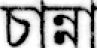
চান্না
